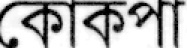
কোকপা
